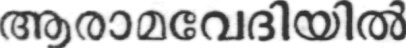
ആരാമവേദിയില്‍
